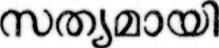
സത്യമായി
